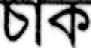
চাক
